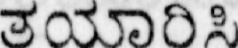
ತಯಾರಿಸಿ
